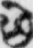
છે
